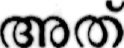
അത്
